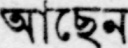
আছেন
